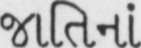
જાતિનાં
